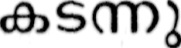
കടന്നു
